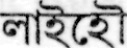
লাইহৌ
